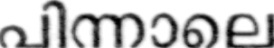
പിന്നാലെ
